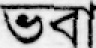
ভবা
